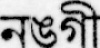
নঙগী
